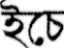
ইচে
